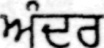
ਅੰਦਰ
